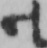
ન
